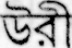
উরী
